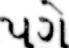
પગે
